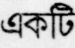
একটি
